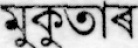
মুকুতাৰ
